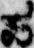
ಪ
